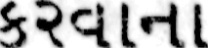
કરવાના
